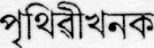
পৃথিৱীখনক
